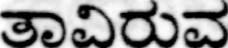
ತಾವಿರುವ
